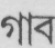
গাব
